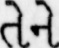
તેને
